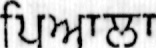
ਪਿਆਲਾ
